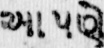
આપણે
